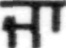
ਜਾ
